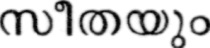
സീതയും
